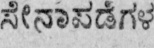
ಸೇನಾಪಡೆಗಳ
